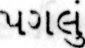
પગલું
